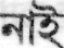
নাই
